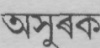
অসুৰক
